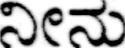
ನೀನು
